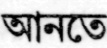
আনতে
